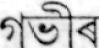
গভীৰ
